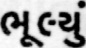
ભૂલ્યું
